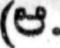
(ಆ.
